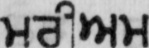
ਮਰੀਅਮ
